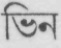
ভিন
